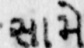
સામે
